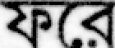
ফরে
